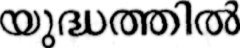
യുദ്ധത്തില്‍
